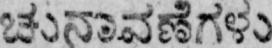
ಚುನಾವಣೆಗಳು
